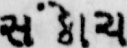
સંકોચ
